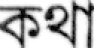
কথা
